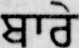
ਬਾਰੇ
